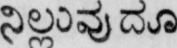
ನಿಲ್ಲುವುದೂ
